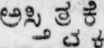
ಅಸ್ತಿತ್ವಕ್ಕೆ
